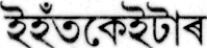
ইহঁতকেইটাৰ
